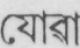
যোৱা
